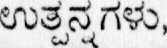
ಉತ್ಪನ್ನಗಳು,
